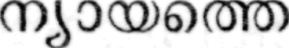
ന്യായത്തെ
